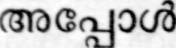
അപ്പോള്‍
